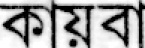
কায়বা
